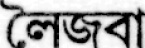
লৈজবা
